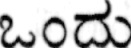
ಒಂದು
